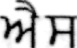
ਐਸ
